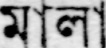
মালা
